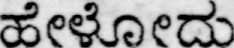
ಹೇಳೋದು
